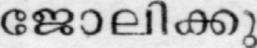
ജോലിക്കു
